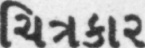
ચિત્રકાર
